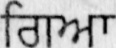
ਗਿਆ
